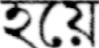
হয়ে
